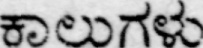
ಕಾಲುಗಳು
